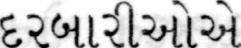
દરબારીઓએ
